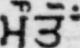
ਮੌਤੋਂ
